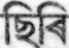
ছিৰি
